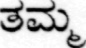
ತಮ್ಮ
